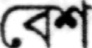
বেশ
